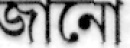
জানো
